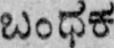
ಬಂಧಕ
